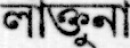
লাক্তুনা
